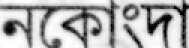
নকোংদা
